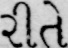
રીતે
